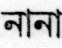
নানা
